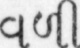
વળી
